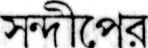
সন্দীপের
